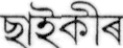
ছাইকীৰ
